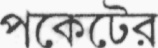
পকেটের
